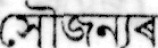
সৌজন্যৰ
